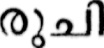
രുചി
